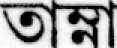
তাম্না
